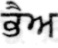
ਭੈਅ
